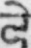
ਕੇ
